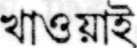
খাওয়াই
